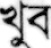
খুব
